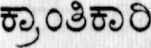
ಕ್ರಾಂತಿಕಾರಿ
